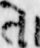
તો
